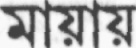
মায়ায়
